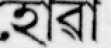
হোৱা
